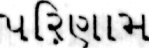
પરિણામ
